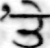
'ਤੇ
